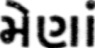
મેણાં
